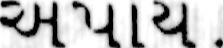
અપાય.
